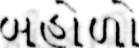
બહોળો
